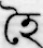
হৈ
